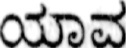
ಯಾವ
